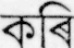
কৰি
